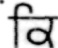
ਕਿ
